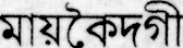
মায়কৈদগী
